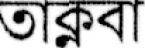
তাক্নবা
